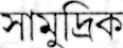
সামুদ্রিক
